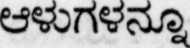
ಆಳುಗಳನ್ನೂ
